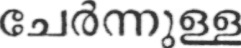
ചേര്‍ന്നുള്ള
